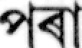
পৰা
